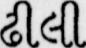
ઢીલી
